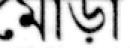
মোড়া
